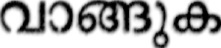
വാങ്ങുക
